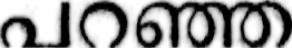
പറഞ്ഞ
